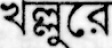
খল্লুরে
